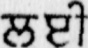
ਲਈ
